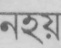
নহয়
